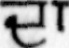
ਦਾ
